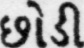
છોડી
